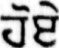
ਹੋਏ
